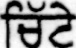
ਚਿੱਟੇ
